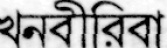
খনবীরিবা
